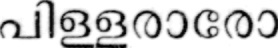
പിള്ളരാരോ
